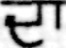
ਦਾ
